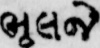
ભૂલજે
